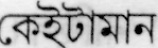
কেইটামান
